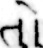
તો
